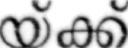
യ്ക്ക്
